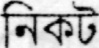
নিকট
